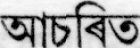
আচৰিত
